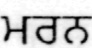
ਮਰਨ
